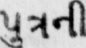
પુત્રની
